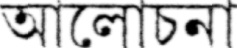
আলোচনা
